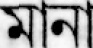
মানা
